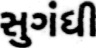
સુગંધી
